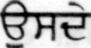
ਉਸਦੇ
